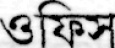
ওফিস
